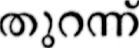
തുറന്ന്
